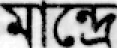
মান্দ্রে
